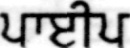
ਪਾਈਪ
